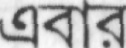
এবার
